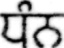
ਧੰਨ
